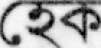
হেক
